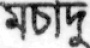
মচাদু
